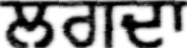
ਲਗਦਾ
